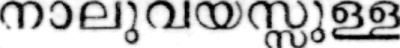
നാലുവയസ്സുള്ള
